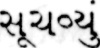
સૂચવ્યું
